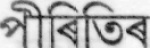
পীৰিতিৰ
